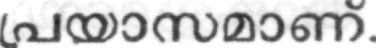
പ്രയാസമാണ്.
